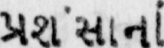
પ્રશંસાનાં
